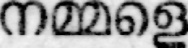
നമ്മളെ
